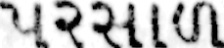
પરસાળ
